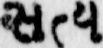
સત્ય
